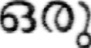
ഒരു
